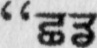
''ਛਡ
